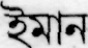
ইমান
